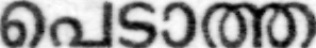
പെടാത്ത
